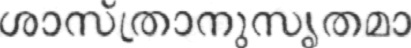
ശാസ്ത്രാനുസൃതമാ
